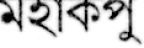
মহাকপু
